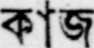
কাজ
